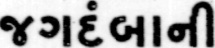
જગદંબાની
